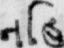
નહિ
